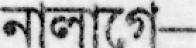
নালাগে-
